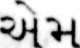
એમ
